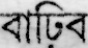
বাঢ়িব
